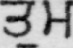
ਤੁਮ
